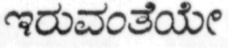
ಇರುವಂತೆಯೇ
